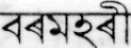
বৰমহৰী
